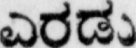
ಎರಡು
